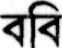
ববি
